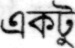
একটু
